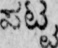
ಪಟ್ಟ
